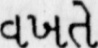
વખતે
